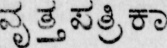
ವೃತ್ತಪತ್ರಿಕಾ
